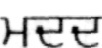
ਮਦਦ
